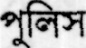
পুলিস
